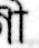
গী
